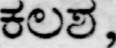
ಕಲಶ,
